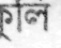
কুলি
